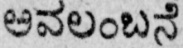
ಅವಲಂಬನೆ
